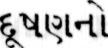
દૂષણનો
